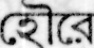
হৌরে
